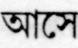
আসে
